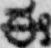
ಈ
